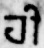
ਹੀ
